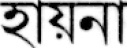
হায়না
